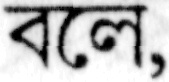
বলে,
